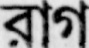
রাগ
